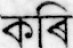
কৰি
